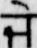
ਜੇ
